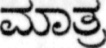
ಮಾತ್ರ
